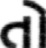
તો
